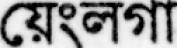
য়েংলগা
